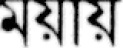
ময়ায়
